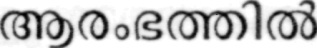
ആരംഭത്തില്‍
